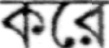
করে
